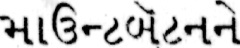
માઉન્ટબૅટનને
